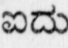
ಐದು
